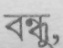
বন্ধু,
